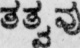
ತತ್ವವು
